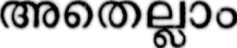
അതെല്ലാം
